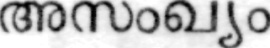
അസംഖ്യം
